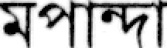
মপান্দা
